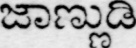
ಜಾಣ್ಣುಡಿ
